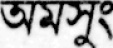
অমসুং
